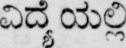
ವಿದ್ಯೆಯಲ್ಲಿ
